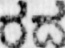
ರದ
